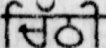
ਚਿੱਠੀ
